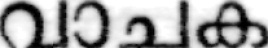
വാചക
